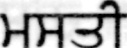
ਮਸਤੀ
